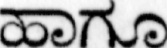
ಹಾಗೂ
